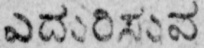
ಎದುರಿಸುವ
